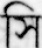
সি
